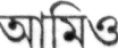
আমিও
